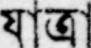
যাত্রা
